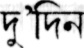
দুদিন
